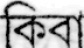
কিবা
